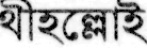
থীহল্লোই
